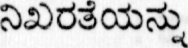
ನಿಖರತೆಯನ್ನು
